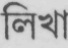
লিখা
